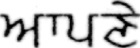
ਆਪਣੇ
